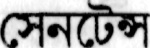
সেনটেন্স
